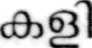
കളി
